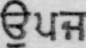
ਉਪਜ
